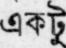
একটু
